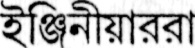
ইঞ্জিনীয়াররা
